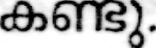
കണ്ടു.
